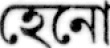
হেনো
